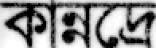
কান্নদ্রে
